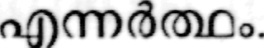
എന്നര്‍ത്ഥം.
